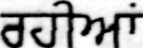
ਰਹੀਆਂ
